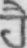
ਹੈ
